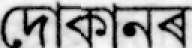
দোকানৰ
